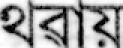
থৱায়
